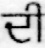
ਦੀ
